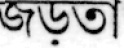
জড়তা
